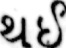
થઈ
